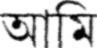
আমি
